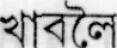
খাবলৈ
